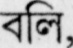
বলি,
